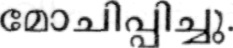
മോചിപ്പിച്ചു.
